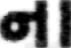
ના
